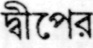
দ্বীপের
